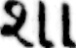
શા
